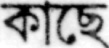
কাছে
